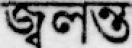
জ্বলন্ত
